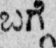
ಬಗ್ಗೆ
